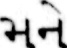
મને
